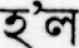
হ'ল
